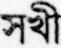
সখী
